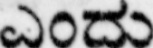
ಎಂದು
